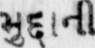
મુદ્દાની
